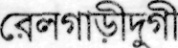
রেলগাড়ীদুগী
